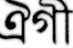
ঐগী
